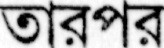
তারপর
